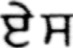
ਏਸ
